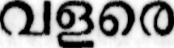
വളരെ
